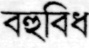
বহুবিধ
